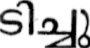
ടിച്ചു
